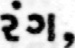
રંગ,
